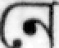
নে
